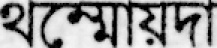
থম্মোয়দা
